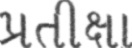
પ્રતીક્ષા
